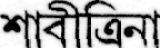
শাবীত্রিনা
